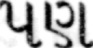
પણ
